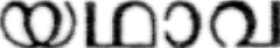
യഥാവ
